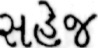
સહેજ
